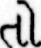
તો
